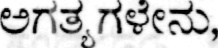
ಅಗತ್ಯಗಳೇನು,
